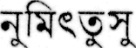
নুমিৎতুসু
